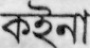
কইনা
